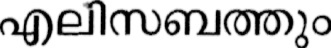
എലിസബത്തും
